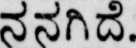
ನನಗಿದೆ.
